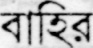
বাহির
